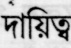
দায়িত্ব
